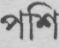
পশি
